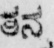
ತನ್ನ
